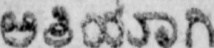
ಅತಿಯಾಗಿ
